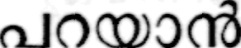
പറയാന്‍
